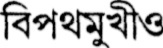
বিপথমুখীও
